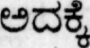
ಅದಕ್ಕೆ
